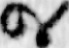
જ
